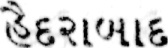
હૈદરાબાદ
